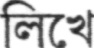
লিখে
